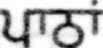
ਪਾਠਾਂ
